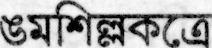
ঙমশিল্লকত্রে
